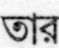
তার
